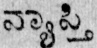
ವ್ಯಾಪ್ತಿ
